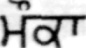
ਮੌਕਾ
